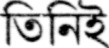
তিনিই
